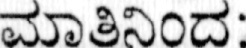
ಮಾತಿನಿಂದ:
